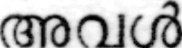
അവള്‍
